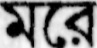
মরে
